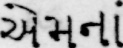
એમનાં
